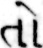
તો
